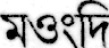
মওংদি
